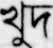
খুদ
